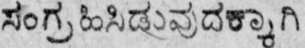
ಸಂಗ್ರಹಿಸಿಡುವುದಕ್ಕಾಗಿ
